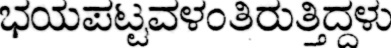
ಭಯಪಟ್ಟವಳಂತಿರುತ್ತಿದ್ದಳು
